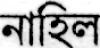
নাহিল
